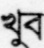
খুব
